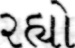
રહ્યો
